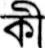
কী
